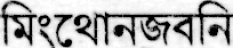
মিংথোনজবনি
